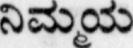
ನಿಮ್ಮಯ
